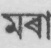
মৰা
